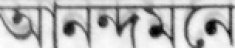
আনন্দমনে
